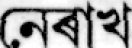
নেৰাখ
